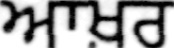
ਆਖ਼ਰ
